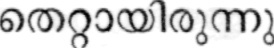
തെറ്റായിരുന്നു
